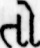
તો
